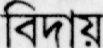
বিদায়
